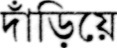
দাঁড়িয়ে
